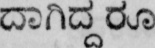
ದಾಗಿದ್ದರೂ
